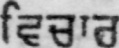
ਵਿਚਾਰ
